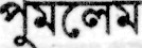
পুমলেম
